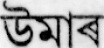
উমাৰ
